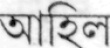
আহিল
